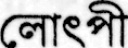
লোৎপী
